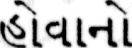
હોવાનો
